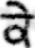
ਕੇ
